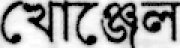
খোঞ্জেল
